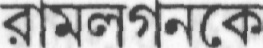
রামলগনকে
